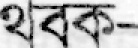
থবক-
